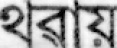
থৱায়
